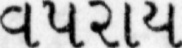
વપરાય
